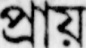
প্রায়
